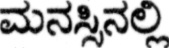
ಮನಸ್ಸಿನಲ್ಲಿ
